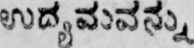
ಉದ್ಯಮವನ್ನು
